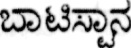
ಬಾಟಿಸ್ಟಾನ
